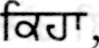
ਕਿਹਾ,
